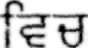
ਵਿਚ
